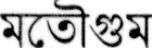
মতৌগুম
